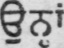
ਉਨ੍ਹਾਂ
